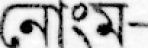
নোংম-
